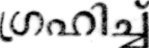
ഗ്രഹിച്ച്
